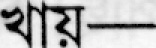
খায়-
